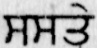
ਸਸਤੇ
